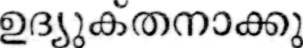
ഉദ്യുക്തനാക്കു
